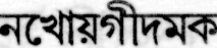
নখোয়গীদমক
